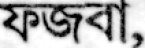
ফজবা,
